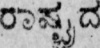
ರಾಷ್ಟ್ರದ
